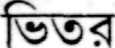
ভিতর
